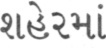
શહેરમાં
